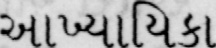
આખ્યાયિકા
